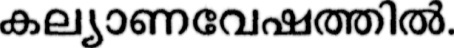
കല്യാണവേഷത്തില്‍.
